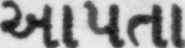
આપતા
